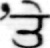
'ਤੇ
